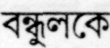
বন্ধুলকে
